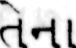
તેના
